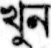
খুন
